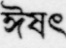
ঈষত্
